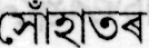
সোঁহাতৰ
